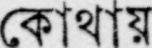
কোথায়
